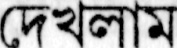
দেখলাম
